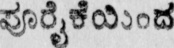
ಪೂರೈಕೆಯಿಂದ
